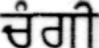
ਚੰਗੀ
